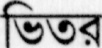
ভিতর
